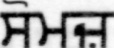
ਸੋਮਜ਼
